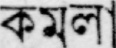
কমলা
